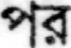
পর
